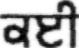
ਕਈ
